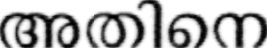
അതിനെ
